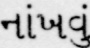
નાંખવું
